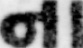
ના
